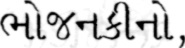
ભોજનકીનો,
